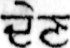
ਦੇਣ
